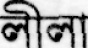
লীলা
